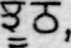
ਝੂਠ,
